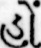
હોં
